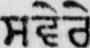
ਸਵੇਰੇ
